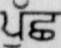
ਪੁੱਛ
